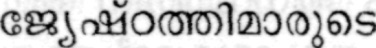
ജ്യേഷ്ഠത്തിമാരുടെ
